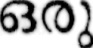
ഒരു
